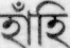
হাঁহি
